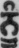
ਨੂੰ
